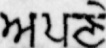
ਅਪਣੇ
